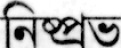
নিষ্প্রভ
